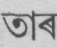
তাৰ
